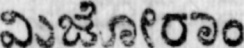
ಮಿಜೋರಾಂ
